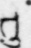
તું
